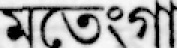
মতেংগা
